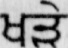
ਖੜੇ
